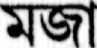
মজা
